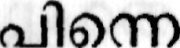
പിന്നെ
